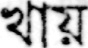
খায়
